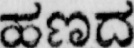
ಹಣದ
